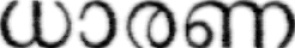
ധാരണ
